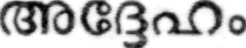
അദ്ദേഹം
